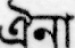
ঐনা
